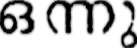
ഒന്നു
